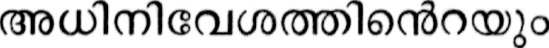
അധിനിവേശത്തിന്റെയും
